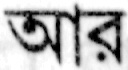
আর
